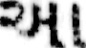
આ
